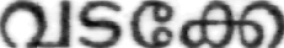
വടക്കേ
